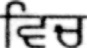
ਵਿਚ
